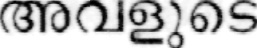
അവളുടെ
